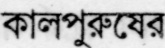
কালপুরুষের
